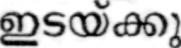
ഇടയ്ക്കു
